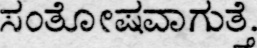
ಸಂತೋಷವಾಗುತ್ತೆ.
